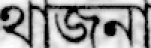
থাজনা
